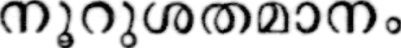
നൂറുശതമാനം
